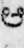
ಆ
